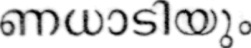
ണധാടിയും
